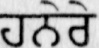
ਹਨੇਰੇ
